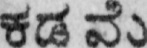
ಕಡಮೆ
